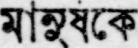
মানুষকে
